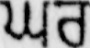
ਘਰ
